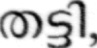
തട്ടി,
